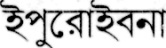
ইপুরোইবনা
